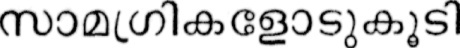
സാമഗ്രികളോടുകൂടി
